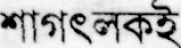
শাগৎলকই
